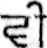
ਵੀ
